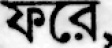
ফরে,
